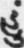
હું
